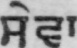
ਸੇਵਾ
